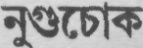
নুগুচোক
